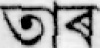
তাৰ
